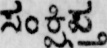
ಸಂಕ್ಷಿಪ್ತ
